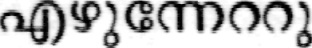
എഴുന്നേററു
